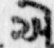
એ
